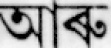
আৰু
